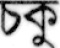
চকু
